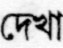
দেখা
